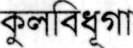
কুলবিধূগা
